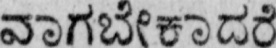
ವಾಗಬೇಕಾದರೆ
